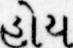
હોય
